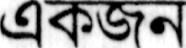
একজন
